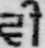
ਵੀ
